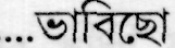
...ভাবিছো
